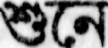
শুনে
